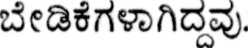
ಬೇಡಿಕೆಗಳಾಗಿದ್ದವು.
